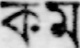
কম
